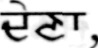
ਦੇਣਾ,
